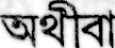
অথীবা
